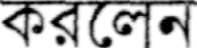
করলেন
